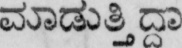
ಮಾಡುತ್ತಿದ್ದಾ
